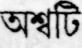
অশ্বটি
